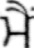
ਮੈਂ
